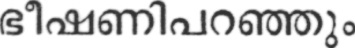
ഭീഷണിപറഞ്ഞും
